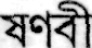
ষণবী
